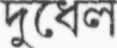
দুধেল
